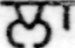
ਲਾ
